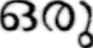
ഒരു
